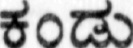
ಕಂಡು
